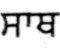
ਸਾਥ
